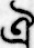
ঐ
